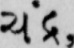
ચંદ્ર,
